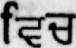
ਵਿਚ
